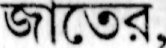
জাতের,
